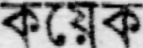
কয়েক
